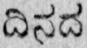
ದಿನದ
